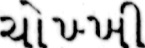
ચોખ્ખી
